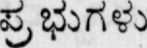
ಪ್ರಭುಗಳು
